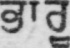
ਭਾਰੂ
